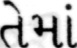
તેમાં
